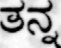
ತನ್ನ
